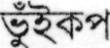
ভুঁইকপ
